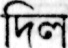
দিল
